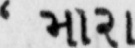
'મારા
